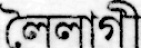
লৈলাগী
